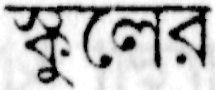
স্কুলের
